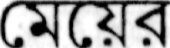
মেয়ের
